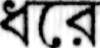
ধরে
